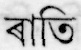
ৰাতি
